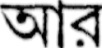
আর
